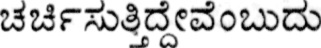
ಚರ್ಚಿಸುತ್ತಿದ್ದೇವೆಂಬುದು
